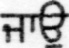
ਜਾਉ
